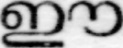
ഈ
